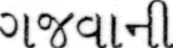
ગજવાની
